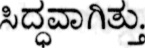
ಸಿದ್ಧವಾಗಿತ್ತು.
